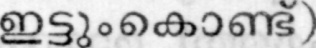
ഇട്ടുംകൊണ്ട്)
